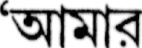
'আমার
